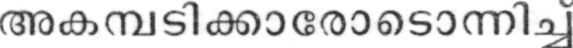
അകമ്പടിക്കാരോടൊന്നിച്ച്
